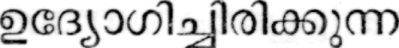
ഉദ്യോഗിച്ചിരിക്കുന്ന
